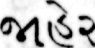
જાહેર
